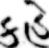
કહે
